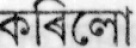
কৰিলো
